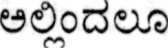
ಅಲ್ಲಿಂದಲೂ
